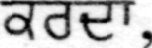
ਕਰਦਾ,
